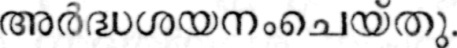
അര്‍ദ്ധശയനംചെയ്തു.
